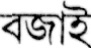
বজাই
